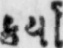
કર્યા
